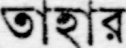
তাহার
